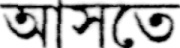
আসতে
